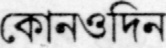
কোনওদিন
